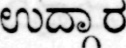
ಉದ್ಗಾರ
